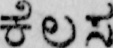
ಕೆಲಸ
